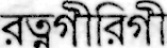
রত্নগীরিগী
